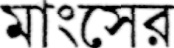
মাংসের
